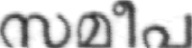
സമീപ
